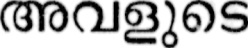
അവളുടെ
